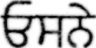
ਓਸਨੇ
